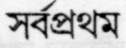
সর্বপ্রথম
